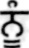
ਨੂੰ
